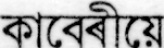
কাবেৰীয়ে
